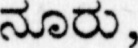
ನೂರು,
